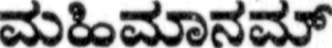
ಮಹಿಮಾನಮ್
